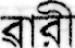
ৱারী
